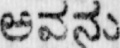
ಅವನು
